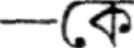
–কে
